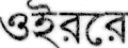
ওইররে
